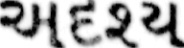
અદ્દશ્ય
